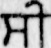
ਸੀ
